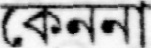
কেননা
